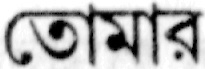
তোমার
